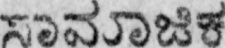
ಸಾಮಾಜಿಕ
